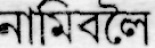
নামিবলৈ
